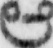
ಆ
